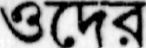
ওদের
